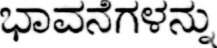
ಭಾವನೆಗಳನ್ನು
